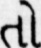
તો
